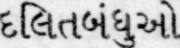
દલિતબંધુઓ
